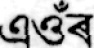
এওঁৰ
